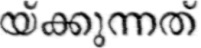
യ്ക്കുന്നത്
